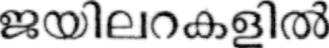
ജയിലറകളില്‍
